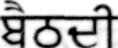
ਬੈਠਦੀ
